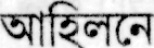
আহিলনে
